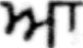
ਆ
